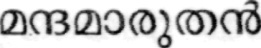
മന്ദമാരുതന്‍
